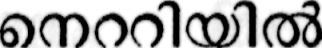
നെററിയില്‍
